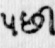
પછી
